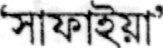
‘সাফাইয়া’
